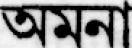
অমনা
